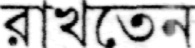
রাখতেন
